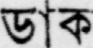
ডাক
